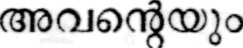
അവന്റെയും
